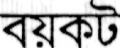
বয়কট
